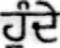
ਹੁੰਦੇ
